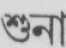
শুনা
